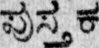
ಪುಸ್ತಕ
